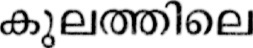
കുലത്തിലെ
